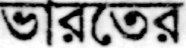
ভারতের
